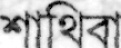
শাথিবা
